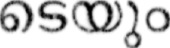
ടെയും
